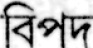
বিপদ
